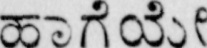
ಹಾಗೆಯೇ
